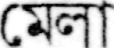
মেলা
